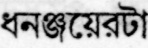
ধনঞ্জয়েরটা
